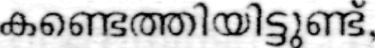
കണ്ടെത്തിയിട്ടുണ്ട്,
